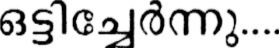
ഒട്ടിച്ചേര്‍ന്നു...
